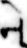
ને
